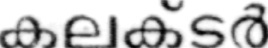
കലക്ടര്‍
